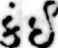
કંઈ
